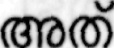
അത്
